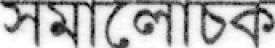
সমালোচ
